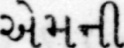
એમની
